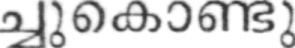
ച്ചുകൊണ്ടു
